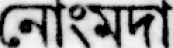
নোংমদা
